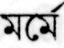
মর্মে
